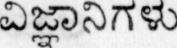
ವಿಜ್ಞಾನಿಗಳು
